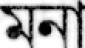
মনা
